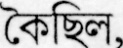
কৈছিল,
